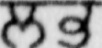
ਲਭ
